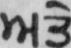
ਅਤੇ
